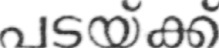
പടയ്ക്ക്
